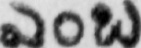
ಎಂಬ
